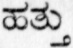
ಹತ್ತು
